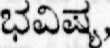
ಭವಿಷ್ಯ,
